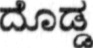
ದೊಡ್ಡ
